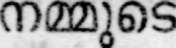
നമ്മുടെ
